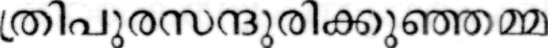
ത്രിപുരസന്ദുരിക്കുഞ്ഞമ്മ
